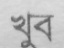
খুব
